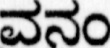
ವನಂ
